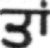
ਤਾਂ
